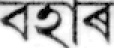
বহাৰ
